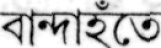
বান্দাহঁতে
